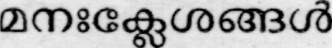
മനഃക്ലേശങ്ങള്‍
